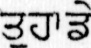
ਤੁਹਾਡੇ
